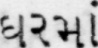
ઘરમાં
